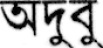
অদুবু
